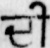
ਦੀ
